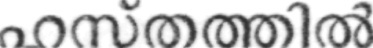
ഹസ്തത്തില്‍
